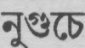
নুগুচে
